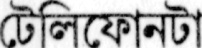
টেলিফোনটা
